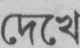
দেখে
